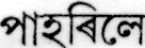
পাহৰিলে
